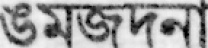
ঙমজদুনা
